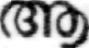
ആ
